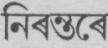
নিৰন্তৰে
